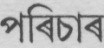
পৰিচাৰ
